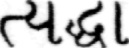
ત્યદ્ધા
